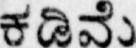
ಕಡಿಮೆ
